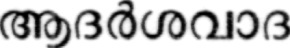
ആദര്‍ശവാദ
